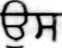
ਉਸ
